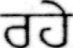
ਰਹੇ
